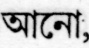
আনো,
